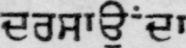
ਦਰਸਾਉਂਦਾ
